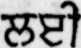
ਲਈ
